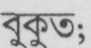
বুকুত;
